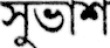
সুভাশ
